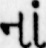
નાં
